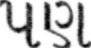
પણ
